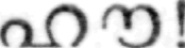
ഹൌ!
